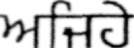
ਅਜਿਹੇ
